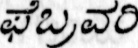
ಫೆಬ್ರವರಿ
